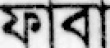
ফাবা
